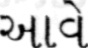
આવે
